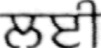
ਲਈ
